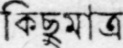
কিছুমাত্র
